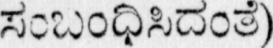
ಸಂಬಂಧಿಸಿದಂತೆ)
